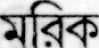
মরিক
